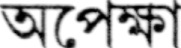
অপেক্ষা
